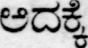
ಅದಕ್ಕೆ
